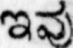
ಇವು
